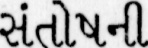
સંતોષની
